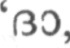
‘ദാ,
